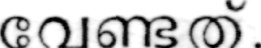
വേണ്ടത്.
